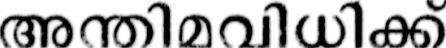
അന്തിമവിധിക്ക്
